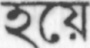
হয়ে
